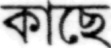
কাছে
